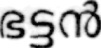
ഭട്ടന്‍
